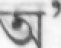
অ'
